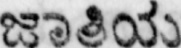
ಜಾತಿಯ
